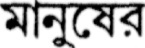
মানুষের
